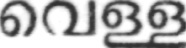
വെള്ള
